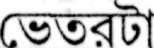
ভেতরটা
